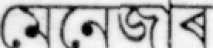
মেনেজাৰ
